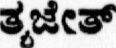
ತ್ಯಜೇತ್
